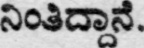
ನಿಂತಿದ್ದಾನೆ.
